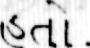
હતો.
